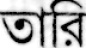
তারি
